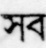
সব
